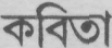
কবিতা
